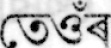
তেওঁৰ
